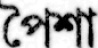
পৈশা
